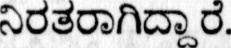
ನಿರತರಾಗಿದ್ದಾರೆ.
